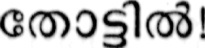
തോട്ടില്‍!
